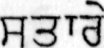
ਸਤਾਰੇ
